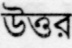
উত্তর
